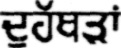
ਦੁਹੱਥੜਾਂ
